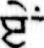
ਏਂ
